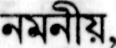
নমনীয়,
